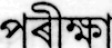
পৰীক্ষা
